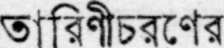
তারিণীচরণের
